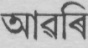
আৱৰি
